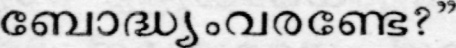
ബോദ്ധ്യംവരണ്ടേ?"
